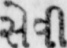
સેવી
